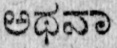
ಅಥವಾ
